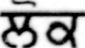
ਲੋਕ
